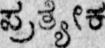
ಪ್ರತ್ಯೇಕ
